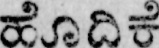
ಹೊದಿಕೆ
